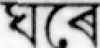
ঘৰে
